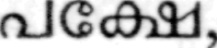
പക്ഷേ,
